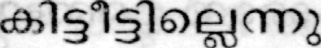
കിട്ടീട്ടില്ലെന്നു
